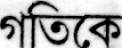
গতিকে
